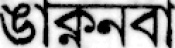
ঙাক্ননবা
